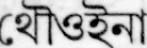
থৌওইনা
